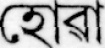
হোৱা
